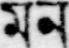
মন
